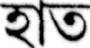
হাত
